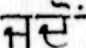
ਜਦੋਂ
